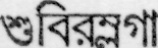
শুবিরম্লগা
